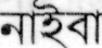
নাইবা
